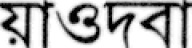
য়াওদবা
